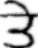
ਤੇ
